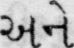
અને
